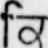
ਕਿ
